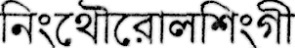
নিথৌরোলশিংগী
